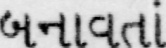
બનાવતાં
